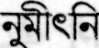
নুমীৎনি
